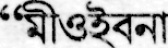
“মীওইবনা
